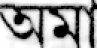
অমা
